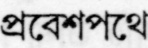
প্রবেশপথে
